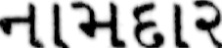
નામદાર
